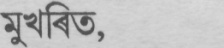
মুখৰিত,
